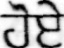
ਹੋਏ
